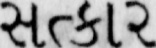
સત્કાર
